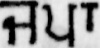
ਜਪਾ
